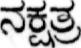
ನಕ್ಷತ್ರ
